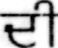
ਦੀ
